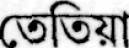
তেতিয়া
